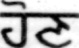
ਹੋਣ
